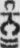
ਨੂੰ
